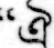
“ঐ
